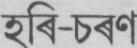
হৰি-চৰণ
